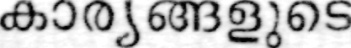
കാര്യങ്ങളുടെ
